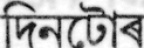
দিনটোৰ
